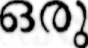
ഒരു
